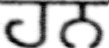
ਹਨ
